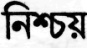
নিশ্চয়
